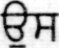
ਉਸ
